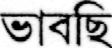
ভাবছি
